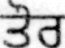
ਤੌਰ
